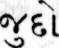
જુદો
